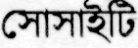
সোসাইটি
